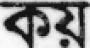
কয়
